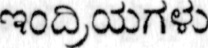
ಇಂದ್ರಿಯಗಳು
